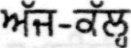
ਅੱਜ-ਕੱਲ੍ਹ
